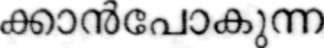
ക്കാന്‍പോകുന്ന
